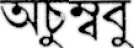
অচুম্ববু
